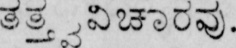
ತತ್ತ್ವವಿಚಾರವು.
